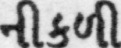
નીકળી
